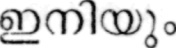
ഇനിയും
